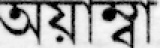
অয়াম্বা
